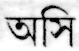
অসি
